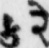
કરે
